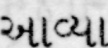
આવ્યા
